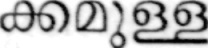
ക്കമുള്ള
